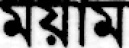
ময়াম
